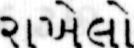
રાખેલો
